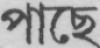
পাছে
